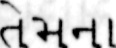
તેમના
